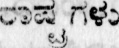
ರಾಷ್ಟ್ರಗಳು
